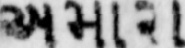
અમારા
